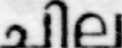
ചില
